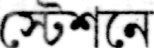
স্টেশনে
